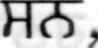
ਸਨ,
